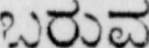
ಬರುವ
